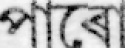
পাৰো
